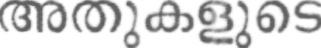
അതുകളുടെ
